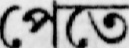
পেতে
